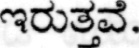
ಇರುತ್ತವೆ.
